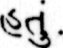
હતું.
